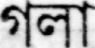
গলা
